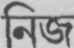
নিজ
